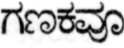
ಗಣಕವೂ
